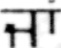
ਜਾਂ
